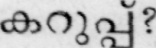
കറുപ്പ്?
